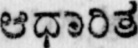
ಆಧಾರಿತ
